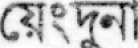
য়েংদুনা
